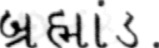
બ્રહ્માંડ.
